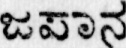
ಜಪಾನ
